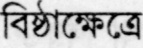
বিষ্ঠাক্ষেত্রে
